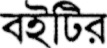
বইটির
